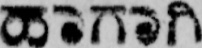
ಹಾಗಾಗಿ
